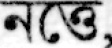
নত্তে,
